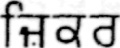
ਜ਼ਿਕਰ
